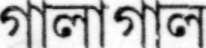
গালাগাল
